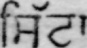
ਸਿੱਟਾ
